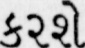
કરશે
